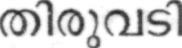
തിരുവടി
